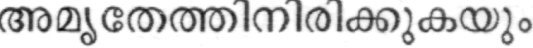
അമൃതേത്തിനിരിക്കുകയും
